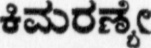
ಕಿಮರಣ್ಯೇ
